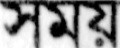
সময়
